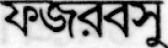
ফজরবসু
